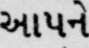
આપને
